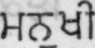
ਮਨੁਖੀ
